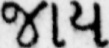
જાય
